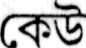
কেউ
